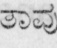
ತಾವು
